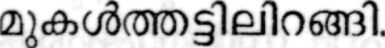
മുകള്‍ത്തട്ടിലിറങ്ങി.
